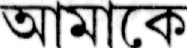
আমাকে
